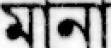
মানা
